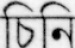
চিনি
